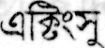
এক্টিংসু
